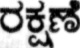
ರಕ್ಷಣೆ
